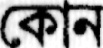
কোন
